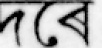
দৰে
